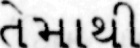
તેમાંથી
